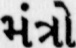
મંત્રો
